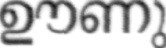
ഊണു
